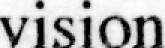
vision
